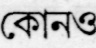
কোনও
